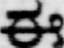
ಈ
